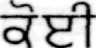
ਕੋਈ
